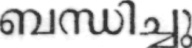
ബന്ധിച്ചു
